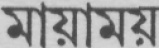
মায়াময়
